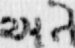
અને
